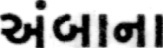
અંબાના
